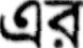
এর
